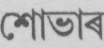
শোভাৰ
